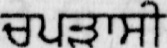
ਚਪੜਾਸੀ
